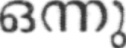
ഒന്നു
